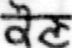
ਕੌਣ
